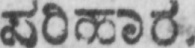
ಪರಿಹಾರ.
